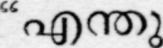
"എന്തു
